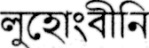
লুহোংবীনি
